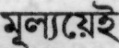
মূল্যয়েই
